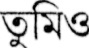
তুমিও
